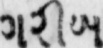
ગરીબ
